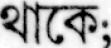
থাকে;
